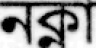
নক্না
